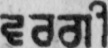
ਵਰਗੀ
